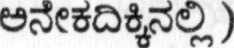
ಅನೇಕದಿಕ್ಕಿನಲ್ಲಿ)
